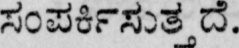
ಸಂಪರ್ಕಿಸುತ್ತದೆ.
